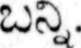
ಬನ್ನಿ.
